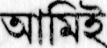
আমিই
